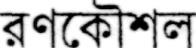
রণকৌশল
